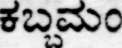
ಕಬ್ಬಮಂ
